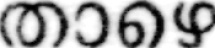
താഴെ
